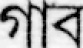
গাব
